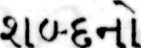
શબ્દનો
